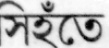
সিহঁতে
